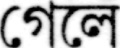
গেলে
